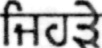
ਜਿਹੜੇ
